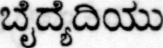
ಬೈದ್ಯೆದಿಯು
